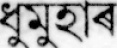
ধুমুহাৰ
